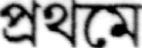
প্রথমে
